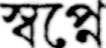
স্বপ্নে
